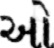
ઓ
